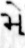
મે
